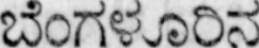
ಬೆಂಗಳೂರಿನ
